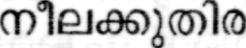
നീലക്കുതിര
